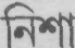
নিশা
